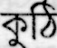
কুঠি
